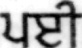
ਪਈ
